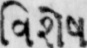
વિશેષ
